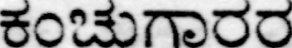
ಕಂಚುಗಾರರ
